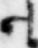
ન
